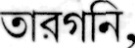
তারগনি,
